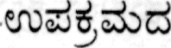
ಉಪಕ್ರಮದ
